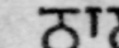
ਨਾਲ
